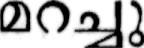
മറച്ചു
